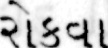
રોકવા
